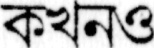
কখনও
